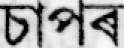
চাপৰ
